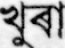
খুৰা
